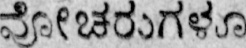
ವೋಚರುಗಳೂ
